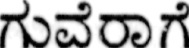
ಗುವೆರಾಗೆ
